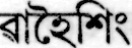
ৱাহৈশিং
